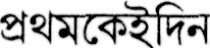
প্রথমকেইদিন
